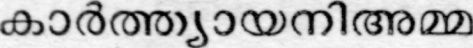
കാര്‍ത്ത്യായനിഅമ്മ
